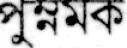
পুম্নমক
